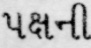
પક્ષની
